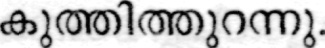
കുത്തിത്തുറന്നു.
